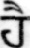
ਹੈ
